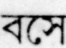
বসে
